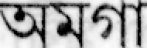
অমগা
